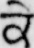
ਕੇ
